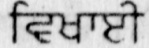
ਵਿਖਾਈ
